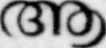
ആ
